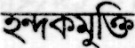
হন্দকমুক্তি
